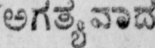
ಅಗತ್ಯವಾದ
